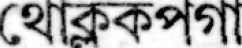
থোক্লকপগা
